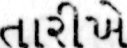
તારીખે
